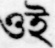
ওই
